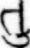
તુ
